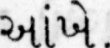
આંખે.
